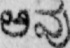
ಅವು
